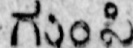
ಗುಂಪಿ
